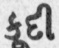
કૂદી
